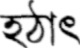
হঠাৎ
